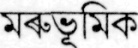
মৰুভূমিক
